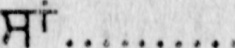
ਸਾਂ..........
